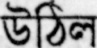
উঠিল
